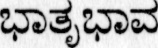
ಭಾತೃಭಾವ
